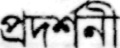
প্রদর্শনী
